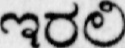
ಇರಲಿ
